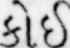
કોઈ
